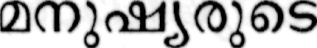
മനുഷ്യരുടെ
